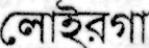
লোইরগা
